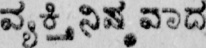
ವ್ಯಕ್ತಿನಿಷ್ಠವಾದ
